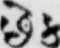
છેક
